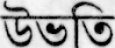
উভতি
